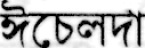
ঈচেলদা
